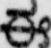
ಈ
